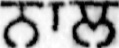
ਨਾਲ
